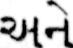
અને
